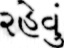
રહેવું
